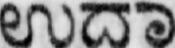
ಉದಾ
